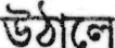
উঠালে
